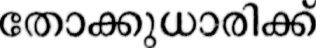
തോക്കുധാരിക്ക്
